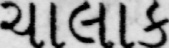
ચાલાક
